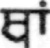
ਥਾਂ
